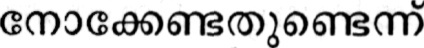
നോക്കേണ്ടതുണ്ടെന്ന്
